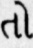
તો
